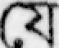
যে
